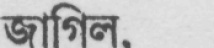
জাগিল,
